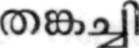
തങ്കച്ചി
